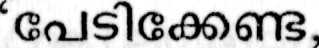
‘പേടിക്കേണ്ട,
